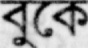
বুকে
